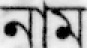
নাম
